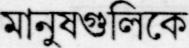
মানুষগুলিকে
